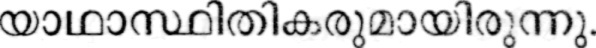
യാഥാസ്ഥിതികരുമായിരുന്നു.
